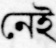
নেই
